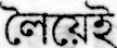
লৈয়েই
